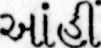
આંહીં
